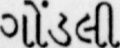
ગોંડલી
